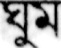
ঘুম
